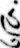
હું
